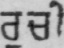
ਰੁਚੀ
